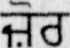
ਜ਼ੋਰ
